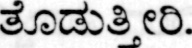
ತೊಡುತ್ತೀರಿ.
